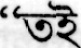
"তই
